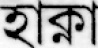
হাক্না
